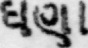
ઘણા
